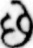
છે
